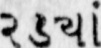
રડ્યાં
